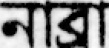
নাব্রা
